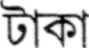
টাকা
